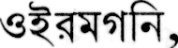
ওইরমগনি,
